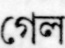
গেল
